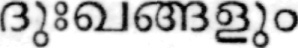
ദുഃഖങ്ങളും
